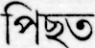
পিছত
